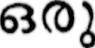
ഒരു
